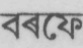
বৰফে
